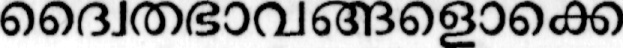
ദ്വൈതഭാവങ്ങളൊക്കെ
